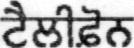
ਟੈਲੀਫ਼ੋਨ
